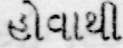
હોવાથી
